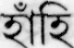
হাঁহি
